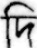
দি
